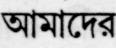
আমাদের
